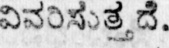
ವಿವರಿಸುತ್ತದೆ.
